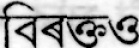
বিৰক্তও
